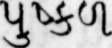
પુષ્કળ
